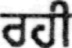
ਰਹੀ
